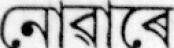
নোৱাৰে
